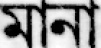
মানা
